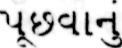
પૂછવાનું
